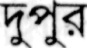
দুপুর
